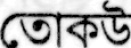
তোকউ
